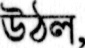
উঠল,
